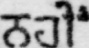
ਨਹੀਂ
